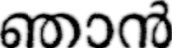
ഞാന്‍
